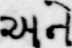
અને
